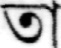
তা
